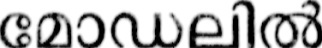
മോഡലില്‍
